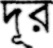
দূর
